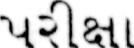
પરીક્ષા
